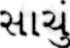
સાચું
